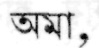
অমা,
